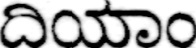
ದಿಯಾಂ
